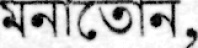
মনাতোন,
